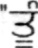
''ਤੂੰ
